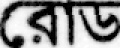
রোড
